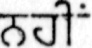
ਨਹੀਂ
